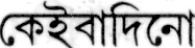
কেইবাদিনো
